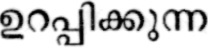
ഉറപ്പിക്കുന്ന
